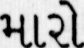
મારો
